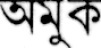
অমুক
